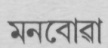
মনবোৱা
